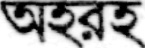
অহরহ
